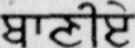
ਬਾਣੀਏ
